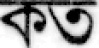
কত
